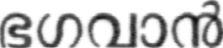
ഭഗവാന്‍
